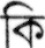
কি
